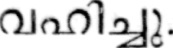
വഹിച്ചു.
